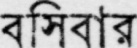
বসিবার
